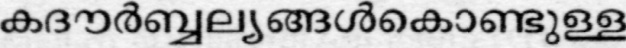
കദൌര്‍ബ്ബല്യങ്ങള്‍കൊണ്ടുള്ള
